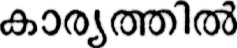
കാര്യത്തില്‍
